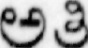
ಅತಿ
